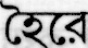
হৈরে
